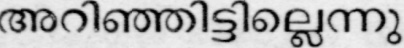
അറിഞ്ഞിട്ടില്ലെന്നു
